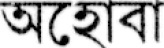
অহোবা
